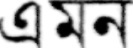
এমন
